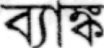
ব্যাঙ্ক
